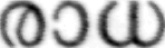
രാധ
